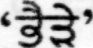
'ਭੈੜੇ'
